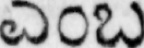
ಎಂಬ
